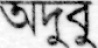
অদুবু
